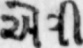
એવી
